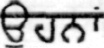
ਉਹਨਾਂ
